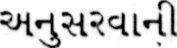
અનુસરવાની
